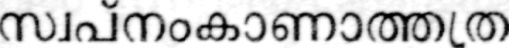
സ്വപ്നംകാണാത്തത്ര
